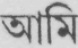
আমি
